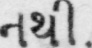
નથી.
